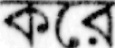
করে
